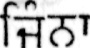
ਜਿੰਨਾ
